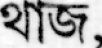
থাজ,
